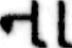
ના
